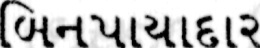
બિનપાયાદાર
